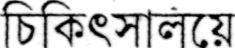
চিকিত্সালয়ে
